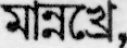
মান্নখ্রে,
